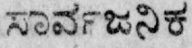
ಸಾರ್ವಜನಿಕ
